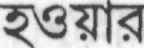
হওয়ার
